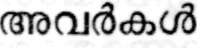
അവര്‍കള്‍
